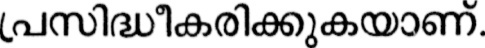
പ്രസിദ്ധീകരിക്കുകയാണ്.
